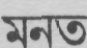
মনত
